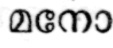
മനോ
